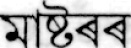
মাষ্টৰৰ
